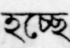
হচ্ছে
